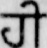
ਹੀ
